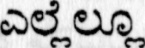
ಎಲ್ಲೆಲ್ಲೂ
